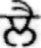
ਲੈ
